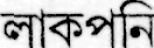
লাকপনি
